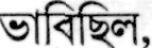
ভাবিছিল,
